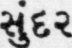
સુંદર
